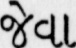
જેવા
